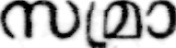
സമ്രാ
